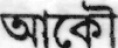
আকৌ
